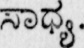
ಸಾಧ್ಯ.
